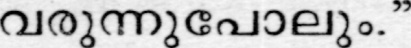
വരുന്നുപോലും."
